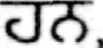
ਹਨ,
